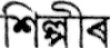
শিল্পীৰ
